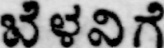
ಬೆಳವಿಗೆ
